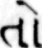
તો
